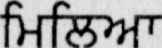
ਮਿਲਿਆ
